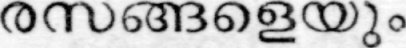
രസങ്ങളെയും
